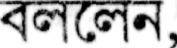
বললেন,
